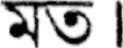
মত।
